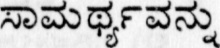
ಸಾಮರ್ಥ್ಯವನ್ನು
